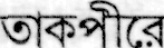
তাকপীরে
